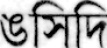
ঙসিদি
